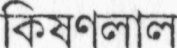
কিষণলাল
